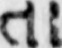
તા
